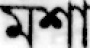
মশা
